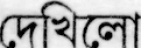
দেখিলো
